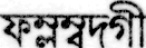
ফম্লম্বদগী
